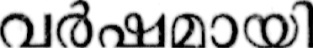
വര്‍ഷമായി
